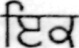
ਇਕ
